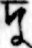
দু
